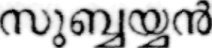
സുബ്ബയ്യന്‍
